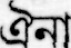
ঐনা
